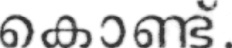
കൊണ്ട്.
